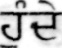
ਹੁੰਦੇ
